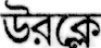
উরক্লে
